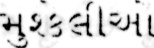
મુશ્કેલીઓ
